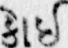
કોઈ
